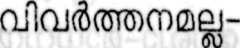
വിവര്‍ത്തനമല്ല-
